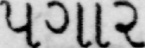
પગાર
